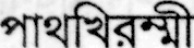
পাথখিরম্মী
